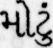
મોટું
